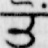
ਤੋਂ
